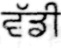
ਵੱਡੀ
